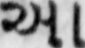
આ
